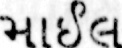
માઈલ
